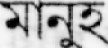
মানুহ
